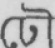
ঢৌ
